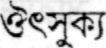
ঔৎসুক্য
